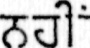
ਨਹੀਂ
